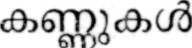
കണ്ണുകള്‍
